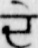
ਦੇ
